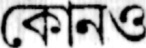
কোনও
